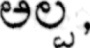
ಅಲ್ಪ,
